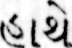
હાથે
